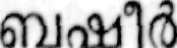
ബഷീര്‍
